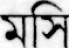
মসি
